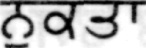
ਨੁਕਤਾ
